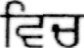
ਵਿਚ
